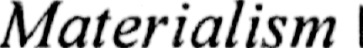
Materialism।
